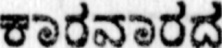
ಕಾರವಾರದ
